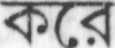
করে
